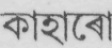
কাহাৰো
